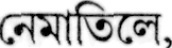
নেমাতিলে,
